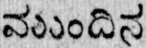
ಮುಂದಿನ
